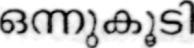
ഒന്നുകൂടി
